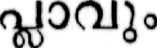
പ്ലാവും
